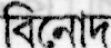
বিনোদ
